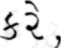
કરે,
